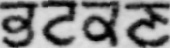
ਭਟਕਣ
